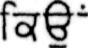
ਕਿਉਂ
